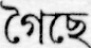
গৈছে
